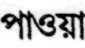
পাওয়া
